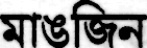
মাঙজিন
